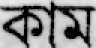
কাম
